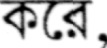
করে,
